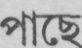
পাছে
